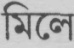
মিলে
